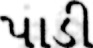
પાડી
